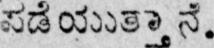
ಪಡೆಯುತ್ತಾನೆ.
